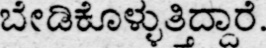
ಬೇಡಿಕೊಳ್ಳುತ್ತಿದ್ದಾರೆ.
